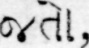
જતો,
